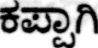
ಕಪ್ಪಾಗಿ
